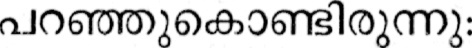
പറഞ്ഞുകൊണ്ടിരുന്നു:
